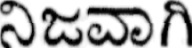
ನಿಜವಾಗಿ
